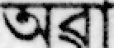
অৱা
